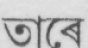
তাৰে
